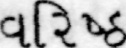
વરિષ્ઠ
